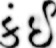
કંઈ
